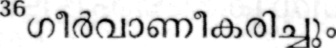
36ഗീര്‍വാണീകരിച്ചും
